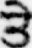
ਤੇ
